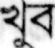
খুব
